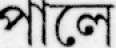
পালে
